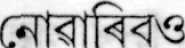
নোৱাৰিবও
